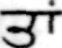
ਤਾਂ
